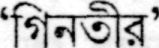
‘গিনতীর’
